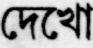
দেখো
